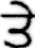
ਤੇ
